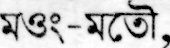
মওং-মতৌ,
